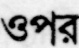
ওপর
